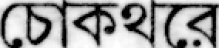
চোকথরে
